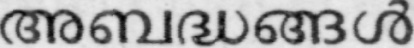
അബദ്ധങ്ങള്‍
